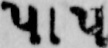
પાપ
